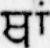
ਥਾਂ
